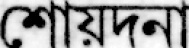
শোয়দনা
